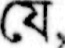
যে,
